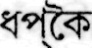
ধপকৈ
